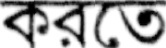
করতে
